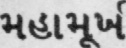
મહામૂર્ખ
